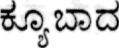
ಕ್ಯೂಬಾದ
